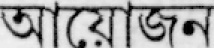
আয়োজন
